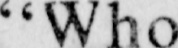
“Who
